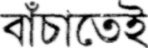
বাঁচাতেই
